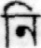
নি
